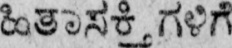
ಹಿತಾಸಕ್ತಿಗಳಿಗೆ
